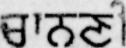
ਚਾਨਣੀ
